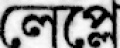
লেপ্লে
